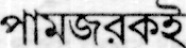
পামজরকই
